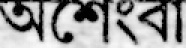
অশেংবা
